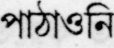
পাঠাওনি
